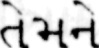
તેમને
